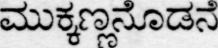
ಮುಕ್ಕಣ್ಣನೊಡನೆ
